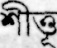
শীত্তূ
